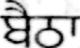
ਬੈਠਾ
